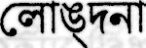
লোঙ্দনা
